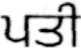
ਪਤੀ
